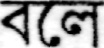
বলে
